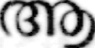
ആ
